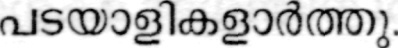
പടയാളികളാര്‍ത്തു.
